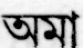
অমা
